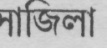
সাজিলা
